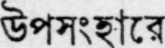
উপসংহারে
